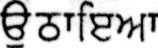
ਉਠਾਇਆ
